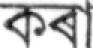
কৰা
